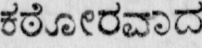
ಕಠೋರವಾದ
